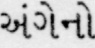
અંગેનો
